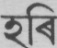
হৰি
